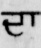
ਦਾ
